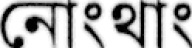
নোংথাং
